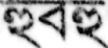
হুবহু
